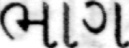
ભાગ
